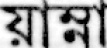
য়াম্না
